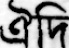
ঐদি
